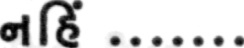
નહિ...
